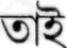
তাই
